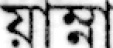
য়াম্না
